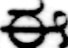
ಈ
